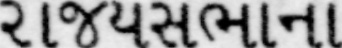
રાજ્યસભાના
